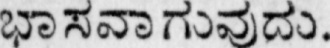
ಭಾಸವಾಗುವುದು.
